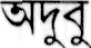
অদুবু
